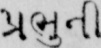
પ્રભુની
